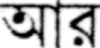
আর
